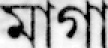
মাগা
